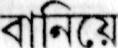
বানিয়ে
